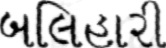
બલિહારી
